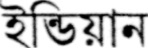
ইন্ডিয়ান
